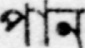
পান
